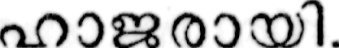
ഹാജരായി.
